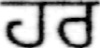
ਹਰ
